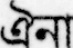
ঐনা
